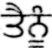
ਤੈਨੂੰ
